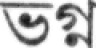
ভগ্ন
